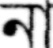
না
